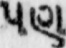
પણ
